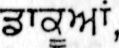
ਡਾਕੂਆਂ,
